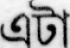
এটা
